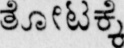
ತೋಟಕ್ಕೆ
